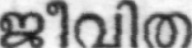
ജീവിത
